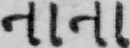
નાના
